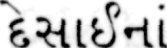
દેસાઈનાં
